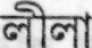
লীলা
